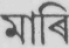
মাৰি
